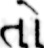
તો
